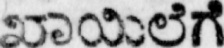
ಖಾಯಿಲೆಗೆ
